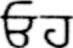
ਓਹ
